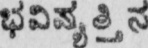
ಭವಿಷ್ಯತ್ತಿನ
